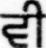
ਵੀ
